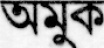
অমুক
